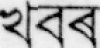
খবৰ
